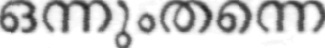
ഒന്നുംതന്നെ
